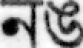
নঙ
